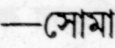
–সোমা
